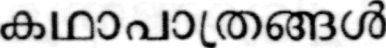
കഥാപാത്രങ്ങള്‍
